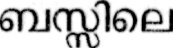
ബസ്സിലെ
